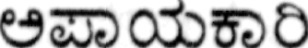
ಅಪಾಯಕಾರಿ
